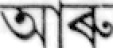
আৰু
